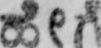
ಹೇಗೆ
